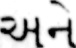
અને
